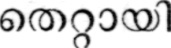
തെറ്റായി
